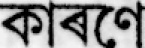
কাৰণে
